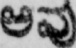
ಅವು
